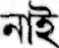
নাই
